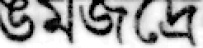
ঙমজদ্রে
